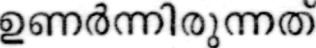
ഉണര്‍ന്നിരുന്നത്
